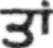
ਤਾਂ
